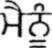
ਮੈਨੂੰ
